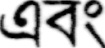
এবং
